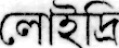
লোইদ্রি
